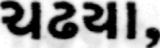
ચઢ્યા,
